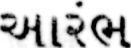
આરંભ
